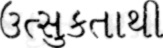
ઉત્સુકતાથી
